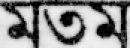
মতম
